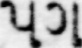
પગ
